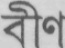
বীণ
